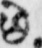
છે.
